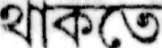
থাকতে
